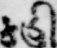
કહી
